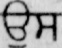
ਉਸ
